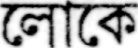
লোকে
